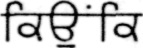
ਕਿਉਂਕਿ
